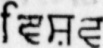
ਵਿਸ਼ਵ
